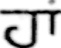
ਹਾਂ
